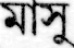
মাসু
